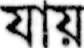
যায়
